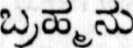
ಬ್ರಹ್ಮನು
